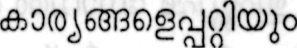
കാര്യങ്ങളെപ്പറ്റിയും
